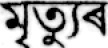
মৃত্যুৰ
